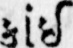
કાંઈ
